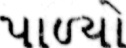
પાળ્યો
